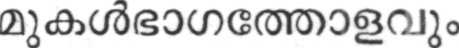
മുകള്‍ഭാഗത്തോളവും
